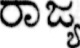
ರಾಜ್ಯ
